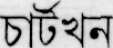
চাৰ্টখন
